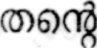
തന്റെ
